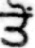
ਤੋਂ
